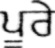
ਪੂਰੇ
